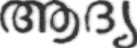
ആദ്യ
